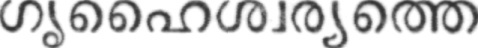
ഗൃഹൈശ്വര്യത്തെ
